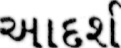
આદર્શ
